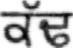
ਕੱਢ
